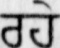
ਰਹੇ
